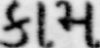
કામ
